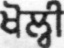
ਖੋਲ੍ਹੀ
